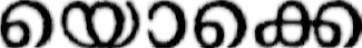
യൊക്കെ
